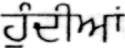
ਹੁੰਦੀਆਂ
